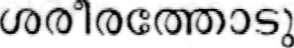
ശരീരത്തോടു
